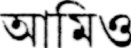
আমিও
